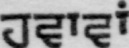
ਹਵਾਵਾਂ
